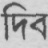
দিব
